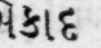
એકાદ
